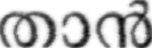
താന്‍
